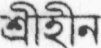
শ্রীহীন
